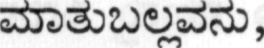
ಮಾತುಬಲ್ಲವನು,
